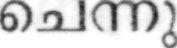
ചെന്നു
